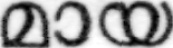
മായ
